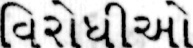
વિરોધીઓ
